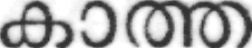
കാത്ത
